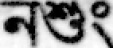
নশুং
